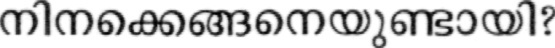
നിനക്കെങ്ങനെയുണ്ടായി?
